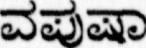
ವಪುಷಾ
